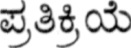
ಪ್ರತಿಕ್ರಿಯೆ
